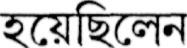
হয়েছিলেন
